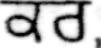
ਕਰ,.
